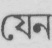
যেন
